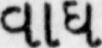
વાઘ
